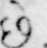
છે.
